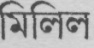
মিলিল
